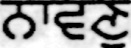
ਨਾਵਣੁ
